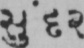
સુંદર
